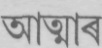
আত্মাৰ
